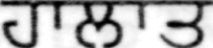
ਹਾਲਾਤ
